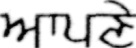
ਆਪਣੇ
